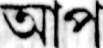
আপ
